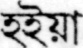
হইয়া
